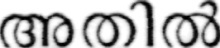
അതില്‍
